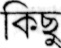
কিছু
